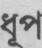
ধূপ
